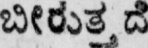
ಬೀರುತ್ತದೆ
